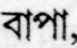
বাপা,
